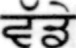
ਵੱਡੇ
